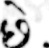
છે.
